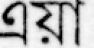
এয়া
